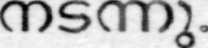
നടന്നു.
